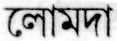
লোমদা
